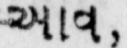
આવ,
